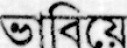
ভাবিয়ে
